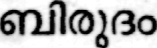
ബിരുദം
